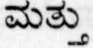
ಮತ್ತು
